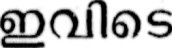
ഇവിടെ
